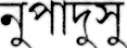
নুপাদুসু
